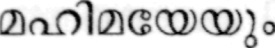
മഹിമയേയും
